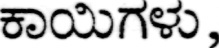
ಕಾಯಿಗಳು,
